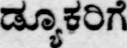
ಡ್ಯೂಕರಿಗೆ
